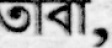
তাবা,
